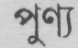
পুণ্য
